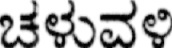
ಚಳುವಳಿ
